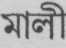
মালী
